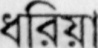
ধরিয়া
